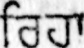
ਰਿਹਾ
